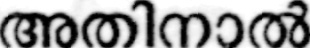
അതിനാല്‍
